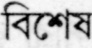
বিশেষ
